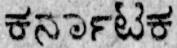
ಕರ್ನಾಟಕ
